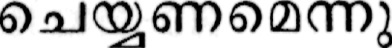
ചെയ്യണമെന്നു
